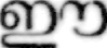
ഈ
